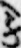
કે
